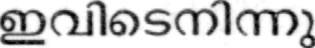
ഇവിടെനിന്നു
